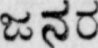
ಜನರ
